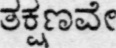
ತಕ್ಷಣವೇ
